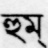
হুম্
